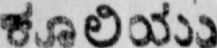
ಕೂಲಿಯು
